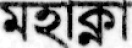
মহাক্না
